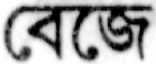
বেজে
